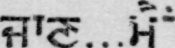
ਜਾਣ.........ਮੈਂ
